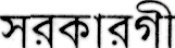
সরকারগী
